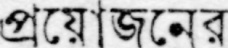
প্রয়োজনের
